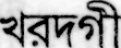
খরদগী
